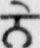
ਨੇ
